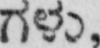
ಗಳು,
